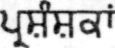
ਪ੍ਰਸ਼ੰਸ਼ਕਾਂ
